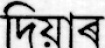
দিয়াৰ
